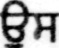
ਉਸ
